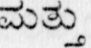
ಮತ್ತು
